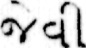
જેવી
